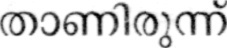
താണിരുന്ന്
